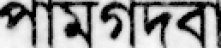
পামগদবা
